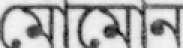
মোমোন
